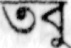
তবু
